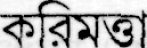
করিমত্তা
